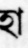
হা
